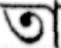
তা
